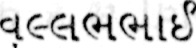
વલ્લભભાઈ
